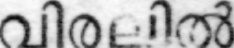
വിരലില്‍
